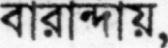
বারান্দায়,
